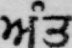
ਅੰਤ
